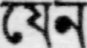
যেন
